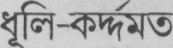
ধূলি-কৰ্দ্দমত
